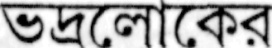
ভদ্রলোকের
